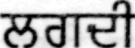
ਲਗਦੀ
